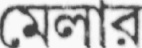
মেলার
